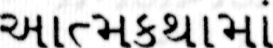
આત્મકથામાં
